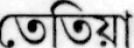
তেতিয়া
